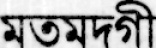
মতমদগী
